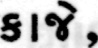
કાજે,
